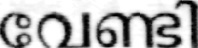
വേണ്ടി
